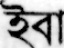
ইবা
